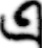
এ
